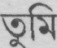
তুমি
